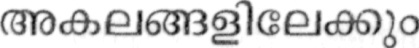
അകലങ്ങളിലേക്കും
